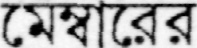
মেম্বারের
